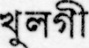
খুলগী
